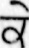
ਕੇ
